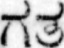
ಗತ
